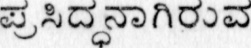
ಪ್ರಸಿದ್ಧನಾಗಿರುವ
